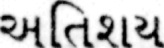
અતિશય
